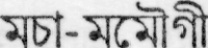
মচা-মমৌগী
